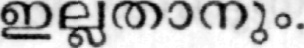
ഇല്ലതാനും.
